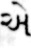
એ
